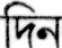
দিন
